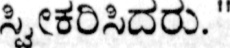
ಸ್ವೀಕರಿಸಿದರು.”
